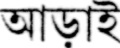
আড়াই
